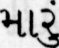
મારું
